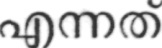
എന്നത്
